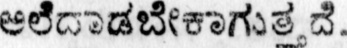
ಅಲೆದಾಡಬೇಕಾಗುತ್ತದೆ.
